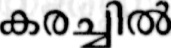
കരച്ചില്‍
